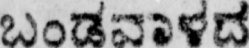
ಬಂಡವಾಳದ
